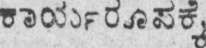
ಕಾರ್ಯರೂಪಕ್ಕೆ
